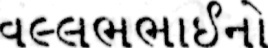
વલ્લભભાઈનો
